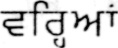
ਵਰ੍ਹਿਆਂ
